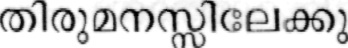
തിരുമനസ്സിലേക്കു
